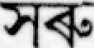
সৰু
